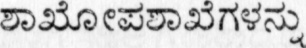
ಶಾಖೋಪಶಾಖೆಗಳನ್ನು
